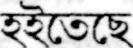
হইতেছে
